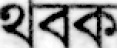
থবক
